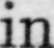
in
